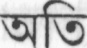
অতি
